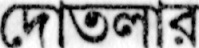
দোতলার
